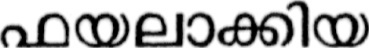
ഫയലാക്കിയ
